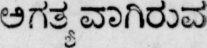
ಅಗತ್ಯವಾಗಿರುವ
